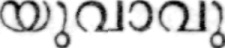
യുവാവു
